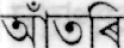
আঁতৰি
